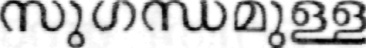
സുഗന്ധമുള്ള
